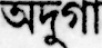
অদুগা
